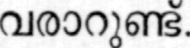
വരാറുണ്ട്.
